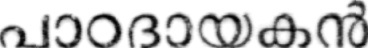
പാഠദായകന്‍
